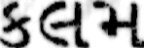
કલમ
